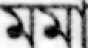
মমা
